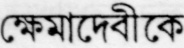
ক্ষেমাদেবীকে
